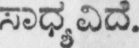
ಸಾಧ್ಯವಿದೆ.
